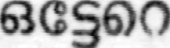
ഒട്ടേറെ
